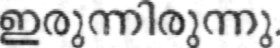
ഇരുന്നിരുന്നു.
